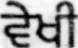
ਵੇਖੀ
